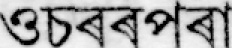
ওচৰৰপৰা
